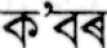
ক'বৰ
